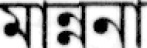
মান্ননা
